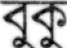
বুকু
